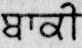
ਬਾਕੀ
